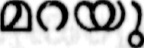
മറയു
